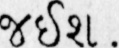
જઈશ.
